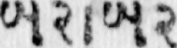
બરાબર
